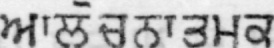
ਆਲੋਚਨਾਤਮਕ
